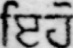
ਇਹੋ
